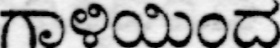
ಗಾಳಿಯಿಂದ
